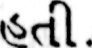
હતી.
